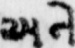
અને
